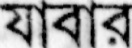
যাবার
